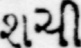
શચી
